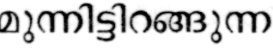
മുന്നിട്ടിറങ്ങുന്ന
